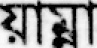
য়াম্না
